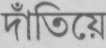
দাঁতিয়ে
